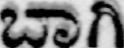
ಬಾಗಿ
